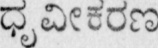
ಧೃವೀಕರಣ
